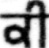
ਕੀ
